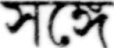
সঙ্গে
